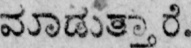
ಮಾಡುತ್ತಾರೆ.
